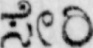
ಸೇರಿ
